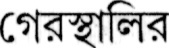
গেরস্থালির
